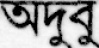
অদুবু
